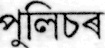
পুলিচৰ
